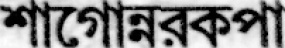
শাগোন্নরকপা
